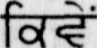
ਕਿਵੇਂ
